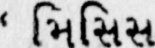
'મિસિસ
